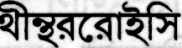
থীন্থররোইসি
